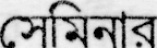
সেমিনার
